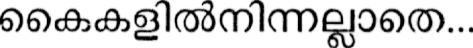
കൈകളില്‍നിന്നല്ലാതെ...
